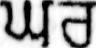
ਘਰ
